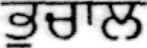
ਭੂਚਾਲ
